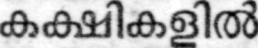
കക്ഷികളില്‍
